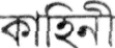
কাহিনী
